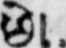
છો.
